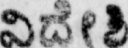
ವಿದೇಶಿ
